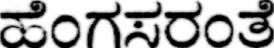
ಹೆಂಗಸರಂತೆ
